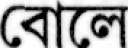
বোলে
